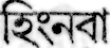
হিংনবা
